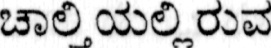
ಚಾಲ್ತಿಯಲ್ಲಿರುವ
